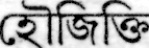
হৌজিক্তি
